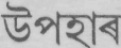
উপহাৰ
